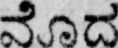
ಮೊದ
